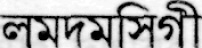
লমদমসিগী
